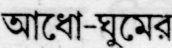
আধো-ঘুমের
